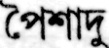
পৈশাদু
